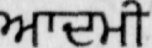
ਆਦਮੀ
